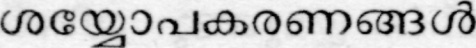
ശയ്യോപകരണങ്ങള്‍
